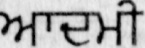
ਆਦਮੀ
